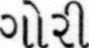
ગોરી
